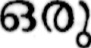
ഒരു
